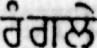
ਰੰਗਲੇ
